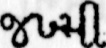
જખ્મી
